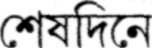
শেষদিনে
